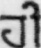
ਹੀ
